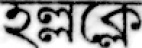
হল্লক্লে
